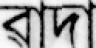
ৱাদা
